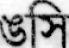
ঙসি
